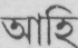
আহি
